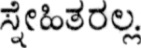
ಸ್ನೇಹಿತರಲ್ಲ.
